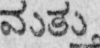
ಮತ್ತು
